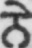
ਨੇ
